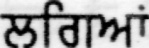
ਲਗਿਆਂ
